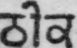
ਠੀਕ
